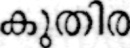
കുതിര
